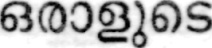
ഒരാളുടെ
